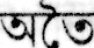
অতৈ
